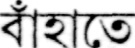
বাঁহাতে
